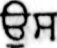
ਉਸ
